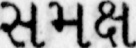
સમક્ષ
